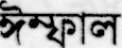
ঈম্ফাল
